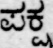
ಪಕ್ಷ
